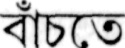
বাঁচতে
